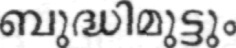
ബുദ്ധിമുട്ടും
